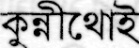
কুন্নীথোই
